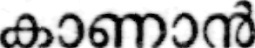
കാണാന്‍
